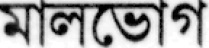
মালভোগ
